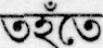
তহঁতে
